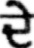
ਦੇ
